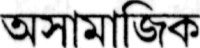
অসামাজিক
